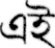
এই
